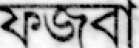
ফজবা
